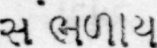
સંભળાય
